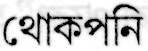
থোকপনি
